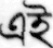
এই
